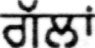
ਗੱਲਾਂ
